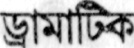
ড্রামাটিক
